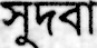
সুদবা
